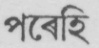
পৰেহি
